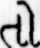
તો
